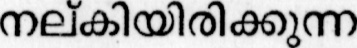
നല്കിയിരിക്കുന്ന
